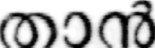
താന്‍
